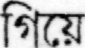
গিয়ে
